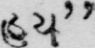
હય”
